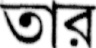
তার
